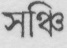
সঞ্চি
